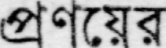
প্রণয়ের
